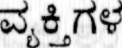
ವ್ಯಕ್ತಿಗಳ
